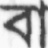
বা
